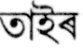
তাইৰ
